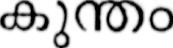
കുന്തം
